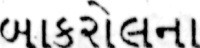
બાકરોલના
